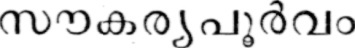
സൌകര്യപൂര്‍വം
